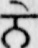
ਨੇ
